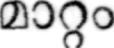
മാറ്റം
